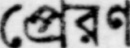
প্রেরণ
